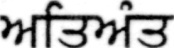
ਅਤਿਅੰਤ
